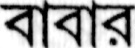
বাবার
